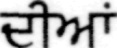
ਦੀਆਂ
